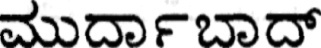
ಮುರ್ದಾಬಾದ್
